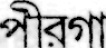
পীরগা
